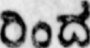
ರಿಂದ
